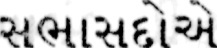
સભાસદોએ
